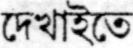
দেখাইতে
